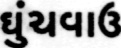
ઘુંચવાઉ
